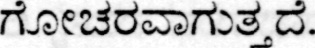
ಗೋಚರವಾಗುತ್ತದೆ.
